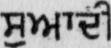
ਸੁਆਦੀ
